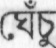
ঘেঁচু
